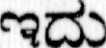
ಇದು
